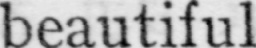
beautiful
